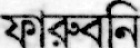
ফারুবনি
